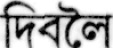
দিবলৈ
